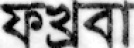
ফখ্রবা
